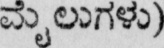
ಮೈಲುಗಳು)
